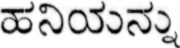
ಹನಿಯನ್ನು
